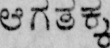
ಆಗತಕ್ಕ
